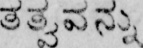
ತತ್ವವನ್ನು
